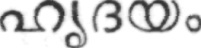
ഹൃദയം
